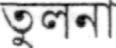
তুলনা
